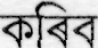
কৰিব
